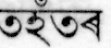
তহঁতৰ
